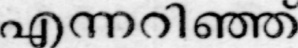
എന്നറിഞ്ഞ്
